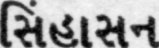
સિંહાસન
